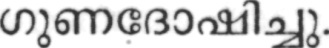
ഗുണദോഷിച്ചു.
